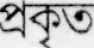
প্রকৃত
